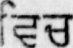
ਵਿਚ
